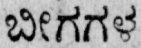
ಬೀಗಗಳ
